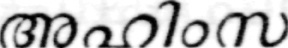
അഹിംസ
